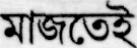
মাজতেই
